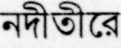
নদীতীরে
